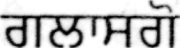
ਗਲਾਸਗੋ
